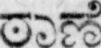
ಠಾಣೆ
